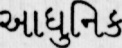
આધુનિક
